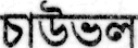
চাউভল
